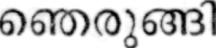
ഞെരുങ്ങി
